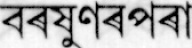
বৰষুণৰপৰা
